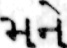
મને
